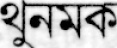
থুনমক
